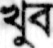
খুব
